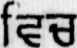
ਵਿਚ
